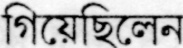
গিয়েছিলেন
